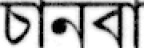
চানবা
